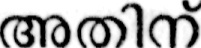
അതിന്
